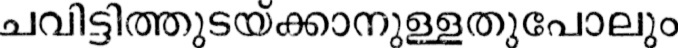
ചവിട്ടിത്തുടയ്ക്കാനുള്ളതുപോലും
